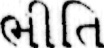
ભીતિ
